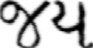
જય
